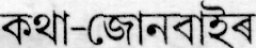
কথা-জোনবাইৰ
